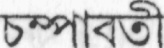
চম্পাবতী
